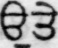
ਉਤੇ
